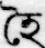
হৈ
